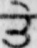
ਤੇ
